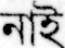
নাই
